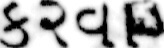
કરવા
